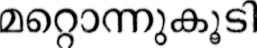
മറ്റൊന്നുകൂടി
